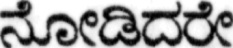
ನೋಡಿದರೇ
